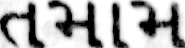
તમામ
